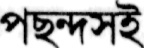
পছন্দসই
